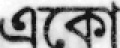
একো
